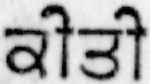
ਕੀਤੀ
